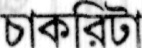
চাকরিটা
